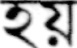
হয়
